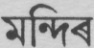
মন্দিৰ
